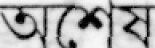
অশেষ
